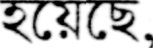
হয়েছে,
